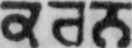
ਕਰਨ
